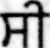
ਸੀ
